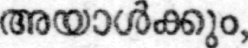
അയാള്‍ക്കും,
